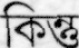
কিন্তু
